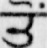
ਤੋਂ
